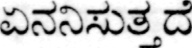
ಏನನಿಸುತ್ತದೆ
